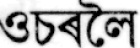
ওচৰলৈ
